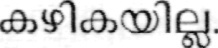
കഴികയില്ല.
